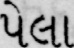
પેલા
